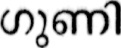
ഗുണി
